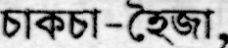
চাকচা-হৈজা,
